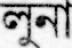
লুনা
